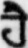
ਹੈ
